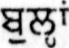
ਬੁਲ੍ਹਾਂ
